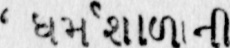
'ધર્મશાળાની
